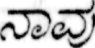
ನಾವು
